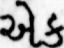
એક
